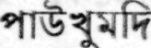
পাউখুমদি
